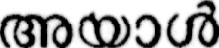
അയാള്‍
